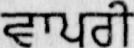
ਵਾਪਰੀ
